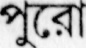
পুরো
